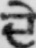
ਦੇ
